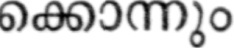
ക്കൊന്നും
